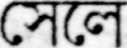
সেলে
